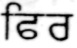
ਫਿਰ
